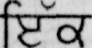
ਇੱਕ
